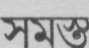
সমস্ত
